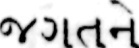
જગતને
